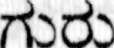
ಗುರು
